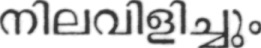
നിലവിളിച്ചും
